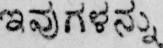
ಇವುಗಳನ್ನು
